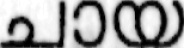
ചായ
